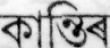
কান্তিৰ
